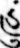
હું
